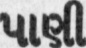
પાણી
